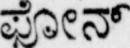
ಫೋನ್
